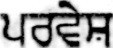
ਪਰਵੇਸ਼
